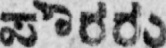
ಪೌರರು
